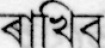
ৰাখিব
